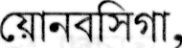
য়োনবসিগা,
